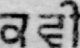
ਕਵੀ
